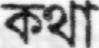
কথা
